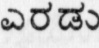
ಎರಡು
